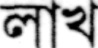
লাখ
